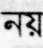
নয়
